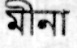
মীনা
